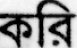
করি
